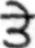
ਤੇ
